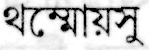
থম্মোয়সু
